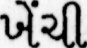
ખેંચી
